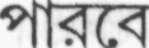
পারবে
